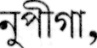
নুপীগা,
